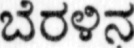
ಬೆರಳಿನ
